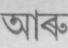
আৰু
